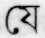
যে
